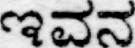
ಇವನ
